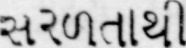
સરળતાથી
